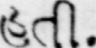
હતી.
